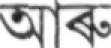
আৰু
